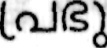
പ്രഭു
